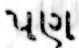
પણ
